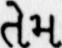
તેમ
